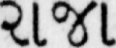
રાજા
